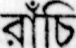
রাঁচি
